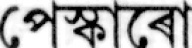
পেস্কাৰো
